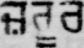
ਜ਼ਰੂਰ
